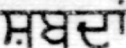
ਸ਼ਬਦਾਂ
